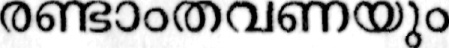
രണ്ടാംതവണയും
